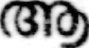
ആ
